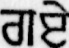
ਗਏ
